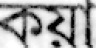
কয়া
